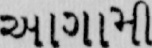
આગામી
